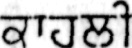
ਕਾਹਲੀ
